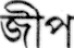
জীপ
